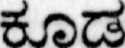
ಕೂಡ
